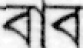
বাব
